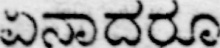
ಏನಾದರೂ
